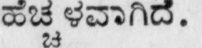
ಹೆಚ್ಚಳವಾಗಿದೆ.
